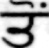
ਤੋਂ
